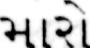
મારો
